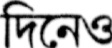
দিনেও
